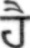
ਹੈ
